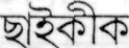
ছাইকীক
